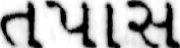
તપાસ
